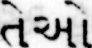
તેઓ
